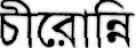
চীরোন্নি
